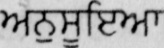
ਅਨੁਸੂਇਆ
